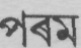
পৰম
